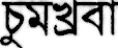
চুমখ্রবা
